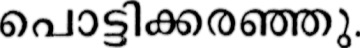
പൊട്ടിക്കരഞ്ഞു.
